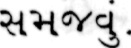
સમજવું.
